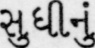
સુધીનું
